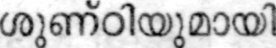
ശുണ്ഠിയുമായി
